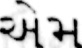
એમ
